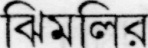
ঝিমলির
